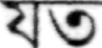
যত
